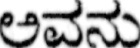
ಅವನು
